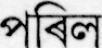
পৰিল
